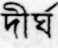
দীর্ঘ
